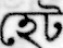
হেট
